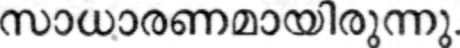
സാധാരണമായിരുന്നു.
